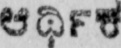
ಆರ್ಥಿಕ
